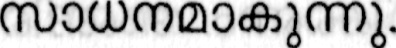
സാധനമാകുന്നു.
